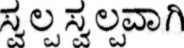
ಸ್ವಲ್ಪಸ್ವಲ್ಪವಾಗಿ
